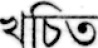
খচিত
